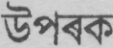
উপৰক
